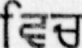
ਵਿਚ
